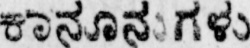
ಕಾನೂನುಗಳು
